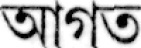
আগত
